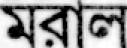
মরাল
